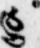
હું
